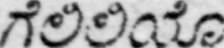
ಗೆಲಿಲಿಯೊ
